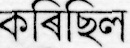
কৰিছিল
